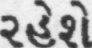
રહેશે
